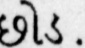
છોડ.
